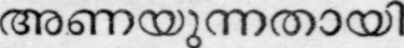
അണയുന്നതായി
